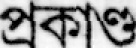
প্রকাণ্ড
